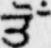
ਤੋਂ
